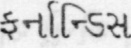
ફર્નાન્ડિસ
